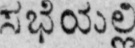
ಸಭೆಯಲ್ಲಿ
